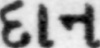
દાન
